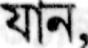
যান,
